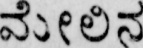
ಮೇಲಿನ
